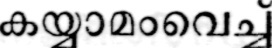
കയ്യാമംവെച്ച്
